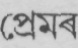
প্ৰেমৰ
